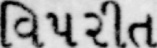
વિપરીત
